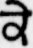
ਕੇ
